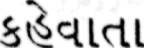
કહેવાતા
